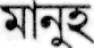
মানুহ
